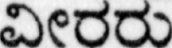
ವೀರರು
